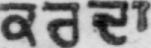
ਕਰਦਾ
